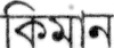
কিমান
